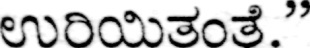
ಉರಿಯಿತಂತೆ."
